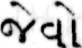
જેવો
